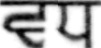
ਵਧ
